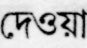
দেওয়া
